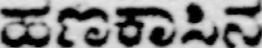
ಹಣಕಾಸಿನ
